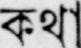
কথা
